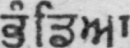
ਭੰਡਿਆ
